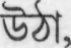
উঠা,
